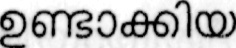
ഉണ്ടാക്കിയ
